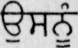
ਉਸਨੂੰ
